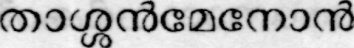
താശ്ശന്‍മേനോന്‍
